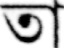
তা
